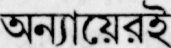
অন্যায়েরই
